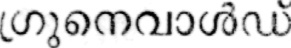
ഗ്രുനെവാള്‍ഡ്
